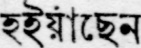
হইয়াছেন
